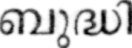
ബുദ്ധി
